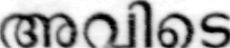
അവിടെ
